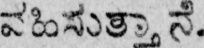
ವಹಿಸುತ್ತಾನೆ.
